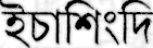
ইচাশিংদি
